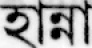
হান্না
